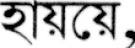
হায়য়ে,
